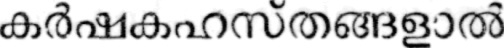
കര്‍ഷകഹസ്തങ്ങളാല്‍
